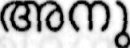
അനു
